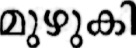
മുഴുകി
